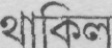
থাকিল
